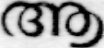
ആ
